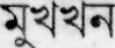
মুখখন
